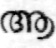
ആ
